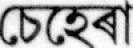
চেহেৰা
